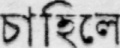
চাহিলে
